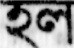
হল
